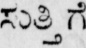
ಸುತ್ತಿಗೆ
